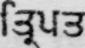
ਤ੍ਰਿਪਤ
